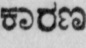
ಕಾರಣ
